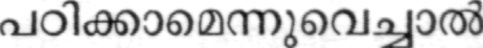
പഠിക്കാമെന്നുവെച്ചാല്‍
